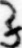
કે
